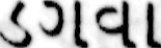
ડગવા
